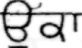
ਉੱਕਾ
